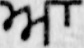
ਆ
